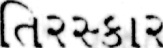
તિરસ્કાર
